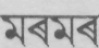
মৰমৰ
